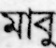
মাবু
